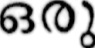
ഒരു
